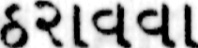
ઠરાવવા
